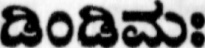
ಡಿಂಡಿಮಃ
